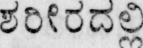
ಶರೀರದಲ್ಲಿ
